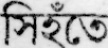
সিহঁতে
